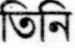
তিনি
